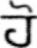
ਹੋ
